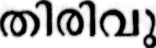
തിരിവു
